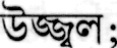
উজ্জ্বল;
